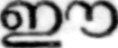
ഈ
